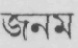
জনম
